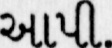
આપી.
